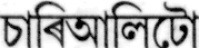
চাৰিআলিটো
